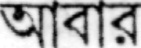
আবার
